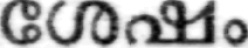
ശേഷം
